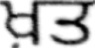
ਖ਼ਤ
